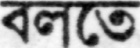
বলতে
